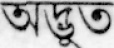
অদ্ভুত
